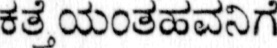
ಕತ್ತೆಯಂತಹವನಿಗೆ
